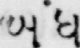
બંધ
